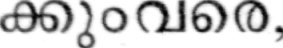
ക്കുംവരെ,
